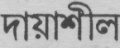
দায়াশীল
